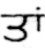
ਤਾਂ
